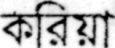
করিয়া
